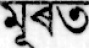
মূৰত
